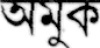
অমুক
